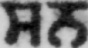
ਸਨ
